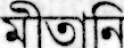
মীতানি
